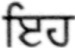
ਇਹ
